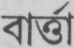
বাৰ্ত্তা
